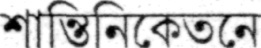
শান্তিনিকেতনে
